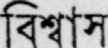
বিশ্বাস
